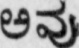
ಅವು
